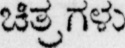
ಚಿತ್ರಗಳು
